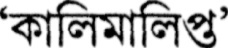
‘কালিমালিপ্ত’
